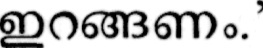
ഇറങ്ങണം.’
